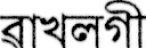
ৱাখলগী
